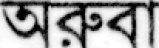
অরুবা
